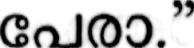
പേരാ.”
